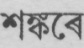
শঙ্কৰে
